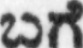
ಬಗೆ
